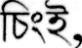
চিংই,
